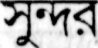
সুন্দর
